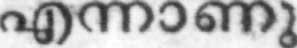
എന്നാണു
